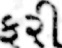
ફરી
